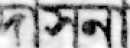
দাসনা
